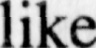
like
